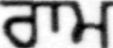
ਰਾਮ
